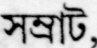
সম্রাট,
